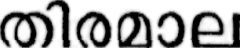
തിരമാല
